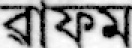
ৱাফম
